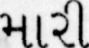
મારી
